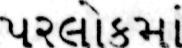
પરલોકમાં
